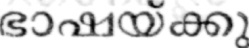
ഭാഷയ്ക്കു
